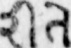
રીતે
